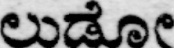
ಲುಡೋ
